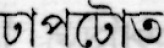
ঢাপটোত
